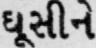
ઘૂસીને
